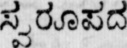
ಸ್ವರೂಪದ
